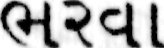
ભરવા
